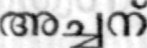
അച്ചന്
